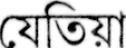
যেতিয়া
